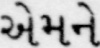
એમને
